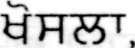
ਖੋਸਲਾ,
